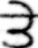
ਤੇ
